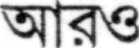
আরও
